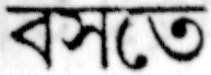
বসতে
